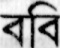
ববি
